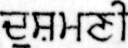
ਦੁਸ਼ਮਣੀ
